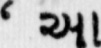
'આ
